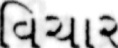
વિચાર
